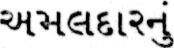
અમલદારનું
